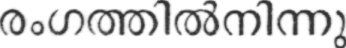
രംഗത്തില്‍നിന്നു
